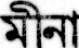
মীনা
